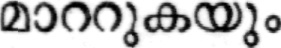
മാററുകയും
